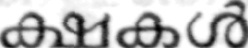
ക്ഷകള്‍
